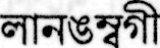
লানঙম্বগী
